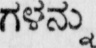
ಗಳನ್ನು
